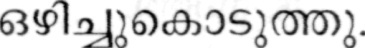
ഒഴിച്ചുകൊടുത്തു.
